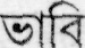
ভাবি
